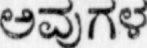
ಅವುಗಳ
